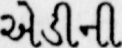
એડીની
